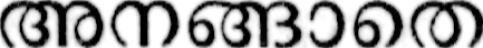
അനങ്ങാതെ
